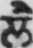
ਲੈ
